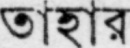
তাহার
